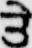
ਤੇ
